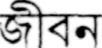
জীবন
